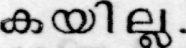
കയില്ല.
